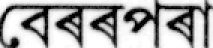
বেৰৰপৰা
